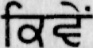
ਕਿਵੇਂ
